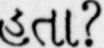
હતા?
